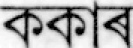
ককাৰ
